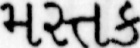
મસ્તક
